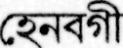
হেনবগী
